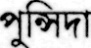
পুন্সিদা
